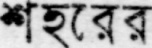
শহরের
